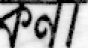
কনা
